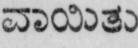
ವಾಯಿತು
